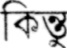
কিন্তু
